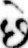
છે
